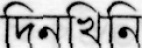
দিনখিনি
